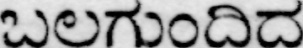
ಬಲಗುಂದಿದ
